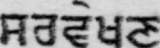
ਸਰਵੇਖਣ
